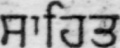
ਸਾਹਿਤ
